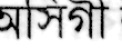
অসিগী
